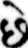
છે
